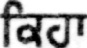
ਕਿਹਾ
